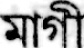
মাগী
